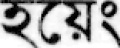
হয়েং
